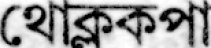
থোক্লকপা
